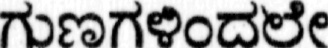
ಗುಣಗಳಿಂದಲೇ
